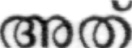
അത്
